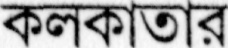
কলকাতার
